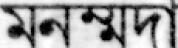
মনম্মদা
